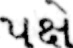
પક્ષે
